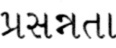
પ્રસન્નતા
